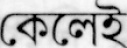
কেলেই
